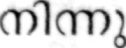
നിന്നു
